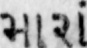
મારાં
